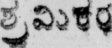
ಶ್ರಮಿಕರ
